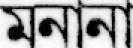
মনানা
